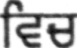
ਵਿਚ
